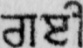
ਗਈ
